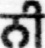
ਨੀ
